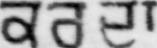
ਕਰਦਾ
